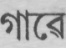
গাৱে
